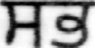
ਸਭ
